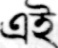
এই
